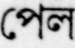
পেল
